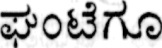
ಘಂಟೆಗೂ
